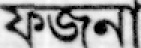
ফজনা
